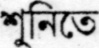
শুনিতে
